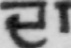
ਦਾ
